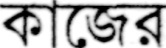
কাজের
